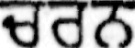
ਚਰਨ
